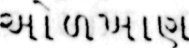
ઓળખાણ
